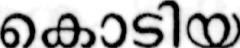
കൊടിയ
